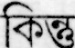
কিন্তু
